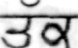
ਤੱਕ
